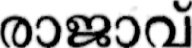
രാജാവ്
